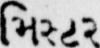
મિસ્ટર
